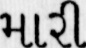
મારી
